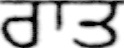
ਰਾਤ
